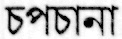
চপচানা
